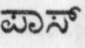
ಪಾಸ್
